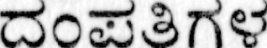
ದಂಪತಿಗಳ
